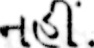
નહીં.
